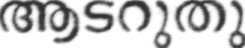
ആടറുതു
